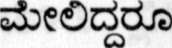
ಮೇಲಿದ್ದರೂ
